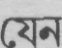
যেন
